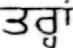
ਤਰ੍ਹਾਂ
